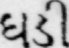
ઘડી
